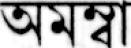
অমম্বা
